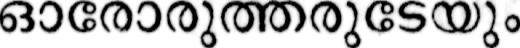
ഓരോരുത്തരുടേയും
